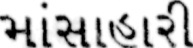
માંસાહારી
